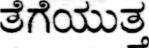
ತೆಗೆಯುತ್ತ
